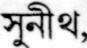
সুনীথ,
